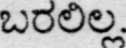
ಬರಲಿಲ್ಲ.
